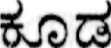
ಕೂಡ
